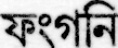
ফংগনি
